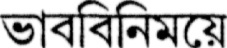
ভাববিনিময়ে
